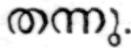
തന്നു.
